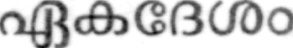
ഏകദേശം
